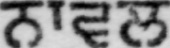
ਨਾਵਲ
